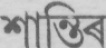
শান্তিৰ
